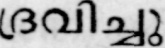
ദ്രവിച്ചു
